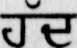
ਹੱਦ
